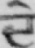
ਦੇ
